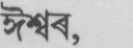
ঈশ্বৰ,
